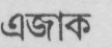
এজাক
